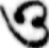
ও
